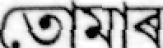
তোমাৰ
